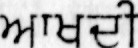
ਆਖਦੀ
